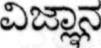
ವಿಜ್ಞಾನ
